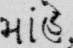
માંહે,
